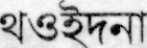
থওইদনা
